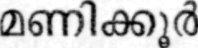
മണിക്കൂര്‍
